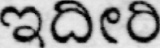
ಇದೀರಿ
